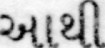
આથી
